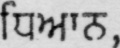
ਧਿਆਨ,
